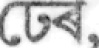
ঢেৰ,
